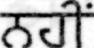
ਨਹੀਂ
